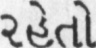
રહેતો
